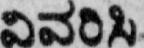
ವಿವರಿಸಿ
